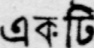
একটি
